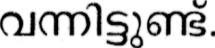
വന്നിട്ടുണ്ട്.
